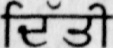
ਦਿੱਤੀ
